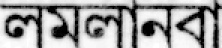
লমলানবা
